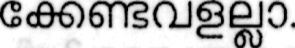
ക്കേണ്ടവളല്ലാ.
